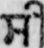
ਸੀ
